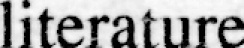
literature
